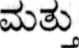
ಮತ್ತು
